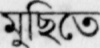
মুছিতে
